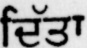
ਦਿੱਤਾ
